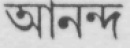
আনন্দ
